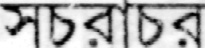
সচরাচর
